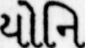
યોનિ
